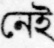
নেই
